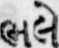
ભલે
